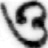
ও
